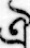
ঐ
